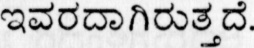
ಇವರದಾಗಿರುತ್ತದೆ.
